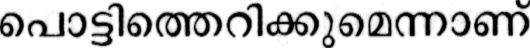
പൊട്ടിത്തെറിക്കുമെന്നാണ്
